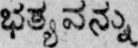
ಭತ್ಯವನ್ನು
